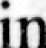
in
